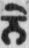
ਨੇ
